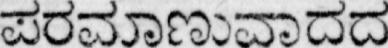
ಪರಮಾಣುವಾದದ
